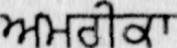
ਅਮਰੀਕਾ
